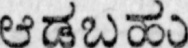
ಆಡಬಹು
